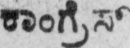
ಕಾಂಗ್ರೆಸ್
